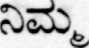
ನಿಮ್ಮ
